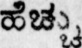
ಹೆಚ್ಚು
